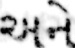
અને
